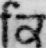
ਕਿ
